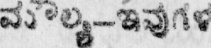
ಮೌಲ್ಯ-ಇವುಗಳ
